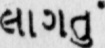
લાગતું
